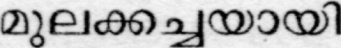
മുലക്കച്ചയായി
